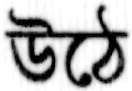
উঠে
